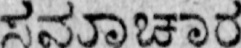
ಸಮಾಚಾರ
